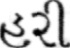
હરી
